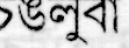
চঙলুবা
